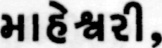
માહેશ્વરી,
